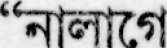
"নালাগে
